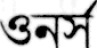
ওনর্স
